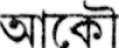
আকৌ
